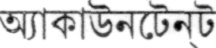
অ্যাকাউনটেন্ট
